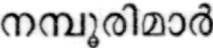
നമ്പൂരിമാര്‍
